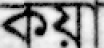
কয়া
